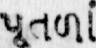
પૂતળાં
